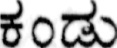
ಕಂಡು
